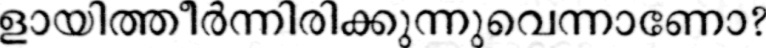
ളായിത്തീര്‍ന്നിരിക്കുന്നുവെന്നാണോ?
